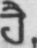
ਹੈ,
